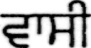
ਵਾਸੀ
